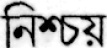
নিশ্চয়
